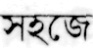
সহজে
